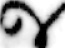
જ
